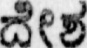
ದೇಶ
